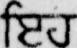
ਇਹ
